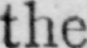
the
